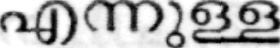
എന്നുള്ള
